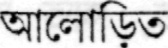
আলোড়িত
